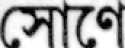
সোণে
